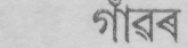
গাঁৱৰ
